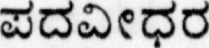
ಪದವೀಧರ
